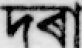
দৰা
